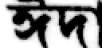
ঈদা
